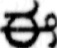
ಈ
